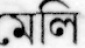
মেলি
